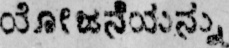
ಯೋಜನೆಯನ್ನು
